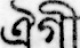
ঐগী
